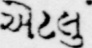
એટલું
